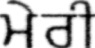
ਮੇਰੀ
